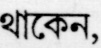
থাকেন,
